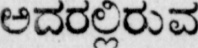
ಅದರಲ್ಲಿರುವ
